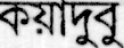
কয়াদুবু
